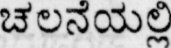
ಚಲನೆಯಲ್ಲಿ
